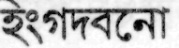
হিংগদবনো
